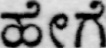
ಹೇಗೆ
